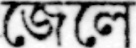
জেলে
